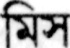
মিস
